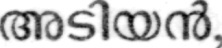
അടിയന്‍,
